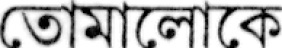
তোমালোকে
